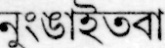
নুংঙাইতবা
